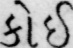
કોઈ
